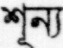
শূন্য
